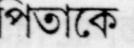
পিতাকে
